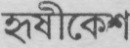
হৃষীকেশ
